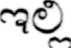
ಇಲ್ಲಿ
